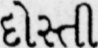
દોસ્તી
